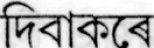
দিবাকৰে
